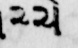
વચ્ચે
